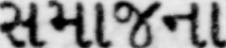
સમાજના
